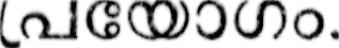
പ്രയോഗം.
